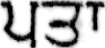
ਪਤਾ
